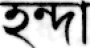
হন্দা
